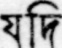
যদি
